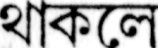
থাকলে
